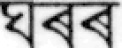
ঘৰৰ
